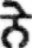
ਨੇ
